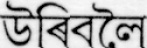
উৰিবলৈ
